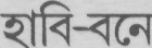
হাবি-বনে
